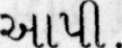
આપી.
